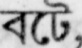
বটে,
